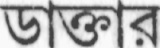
ডাক্তার
